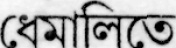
ধেমালিতে
